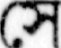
সে
